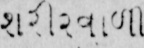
શરીરવાળી
